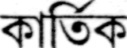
কার্তিক
